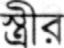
স্ত্রীর
